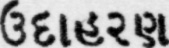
ઉદાહરણ
